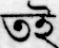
তই
